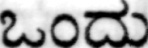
ಒಂದು
